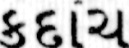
કદાચ
